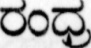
ರಂಧ್ರ
